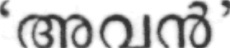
‘അവന്‍'
